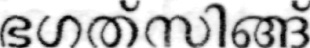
ഭഗത്സിങ്ങ്
